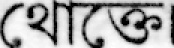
থোক্তে।
